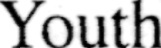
Youth
